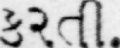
કરતી.
